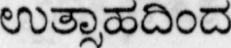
ಉತ್ಸಾಹದಿಂದ
